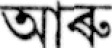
আৰু
